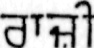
ਰਾਜ਼ੀ
